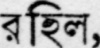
রহিল,
